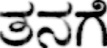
ತನಗೆ
